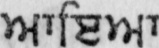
ਆਇਆ
